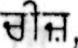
ਚੀਜ਼,
